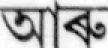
আৰু
